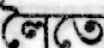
লৈতে
